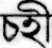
চহী
